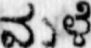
ಮಳೆ
